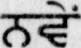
ਨਵੇਂ
